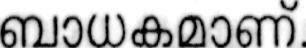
ബാധകമാണ്.
